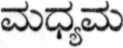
ಮಧ್ಯಮ
